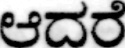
ಆದರೆ
